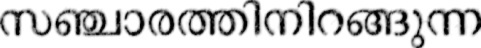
സഞ്ചാരത്തിനിറങ്ങുന്ന
